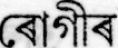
ৰোগীৰ
